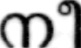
നീ
